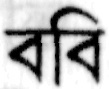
ববি
